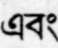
এবং
